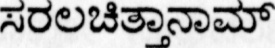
ಸರಲಚಿತ್ತಾನಾಮ್
